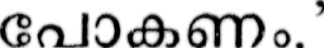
പോകണം.’
